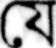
যে
